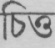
চিত্ত
